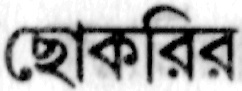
ছোকরির
